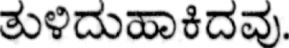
ತುಳಿದುಹಾಕಿದವು.
